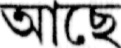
আছে
